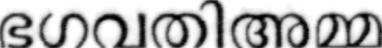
ഭഗവതിഅമ്മ
